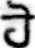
ਹੋ
